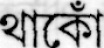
থাকোঁ
